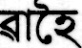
ৱাহৈ
